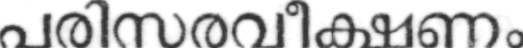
പരിസരവീക്ഷണം
